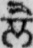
ਲੈ
